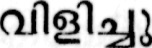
വിളിച്ചു
